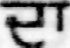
ਦਾ
